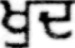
ਖੁਦ
